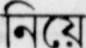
নিয়ে
